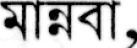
মান্নবা,
